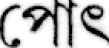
পোৎ
